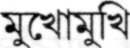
মুখোমুখি
